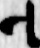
ન
